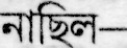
নাছিল-
